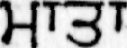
ਮਾਤਾ
